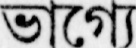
ভাগ্যে
